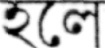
হলে
